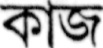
কাজ
